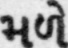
મળે
